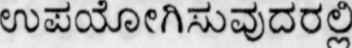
ಉಪಯೋಗಿಸುವುದರಲ್ಲಿ
